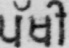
ਪੱਖੀ
